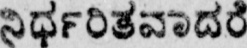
ನಿರ್ಧರಿತವಾದರೆ
